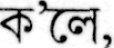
ক'লে,
